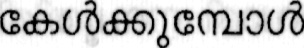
കേള്‍ക്കുമ്പോള്‍
